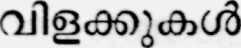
വിളക്കുകള്‍
